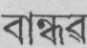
বান্ধৱ
